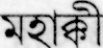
মহাক্কী
